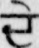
ਦੇ
